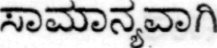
ಸಾಮಾನ್ಯವಾಗಿ
